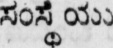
ಸಂಸ್ಥೆಯು
